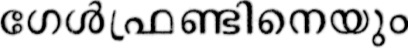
ഗേള്‍ഫ്രണ്ടിനെയും
